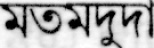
মতমদুদা
